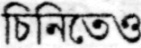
চিনিতেও
